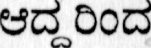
ಆದ್ದರಿಂದ
